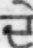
ਦੇ
